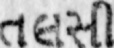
તલસી
